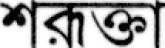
শরূক্তা
